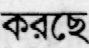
করছে
